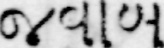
જવાબ
